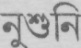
নুশুনি
